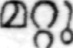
മറ്റു
